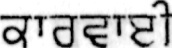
ਕਾਰਵਾਈ
